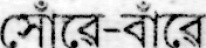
সোঁৱে-বাঁৱে
